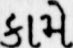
કામે
